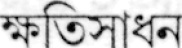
ক্ষতিসাধন
